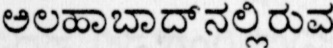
ಅಲಹಾಬಾದ್‌ನಲ್ಲಿರುವ
